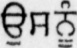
ਉਸਨੂੰ
